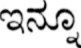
ಇನ್ನೂ
